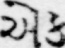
એક
